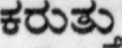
ಕರುತ್ತು
